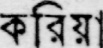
করিয়া
